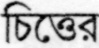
চিত্তের
